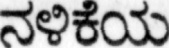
ನಳಿಕೆಯ
